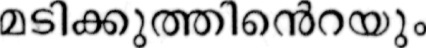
മടിക്കുത്തിന്റെയും
